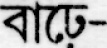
বাঢ়ে-
